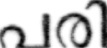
പരി
